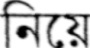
নিয়ে
